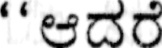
"ಆದರೆ
